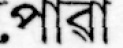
পোৱা
